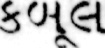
કબૂલ
